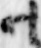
ન
